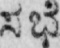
ಸಭೆ
